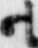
ન
